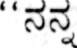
"ನನ್ನ
